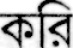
করি
